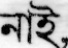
নাই,
